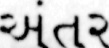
અંતર
